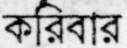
করিবার
